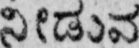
ನೀಡುವ
